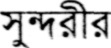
সুন্দরীর
